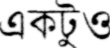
একটুও
